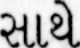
સાથે
